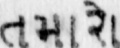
તમારો
